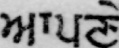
ਆਪਣੇ
